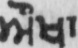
ਔਖਾ
